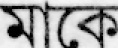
মাকে
